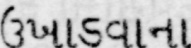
ઉખાડવાના
